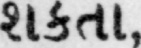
શકતા,
